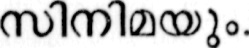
സിനിമയും.
